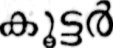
കൂട്ടര്‍
